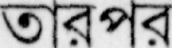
তারপর
